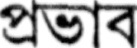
প্রভাব
